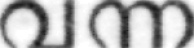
വന്ന
